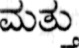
ಮತ್ತು
